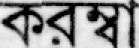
করম্বা
